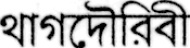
থাগদৌরিবী
